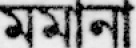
মমানা
